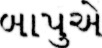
બાપુએ
